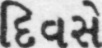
દિવસે
